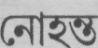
নোহন্ত
